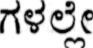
ಗಳಲ್ಲೇ
